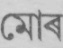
মোৰ
